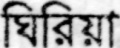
ঘিরিয়া
